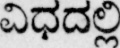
ವಿಧದಲ್ಲಿ
